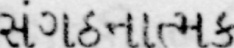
સંગઠનાત્મક
